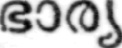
ഭാര്യ
